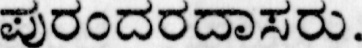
ಪುರಂದರದಾಸರು.
